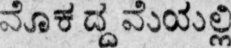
ಮೊಕದ್ದಮೆಯಲ್ಲಿ
